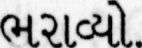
ભરાવ્યો.
